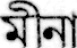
মীনা
